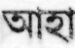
আহা
